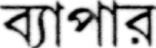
ব্যাপার
